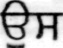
ਉਸ
